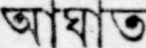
আঘাত
